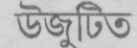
উজুটিত
